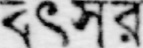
বৎসর
